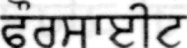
ਫੌਰਸਾਈਟ
